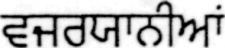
ਵਜਰਯਾਨੀਆਂ
